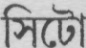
সিটো
